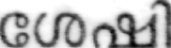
ശേഷി
